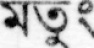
মতুং
